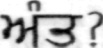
ਅੰਤ?
